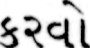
કરવો
